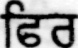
ਫਿਰ
